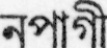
নপাগী
